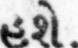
હશે.
